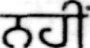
ਨਹੀਂ
